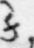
કે,
